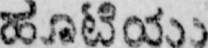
ಹೂಟೆಯು
